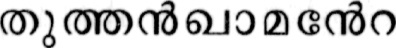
തുത്തന്‍ഖാമന്റേ
